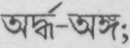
অৰ্দ্ধ-অঙ্গ;
